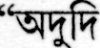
“অদুদি
